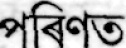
পৰিণত
